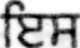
ਇਸ
